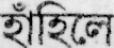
হাঁহিলে
